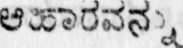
ಆಹಾರವನ್ನು
